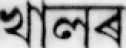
খালৰ
